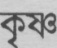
কৃষ্ণ
